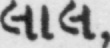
લાલ,
